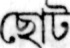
ছোট
